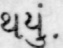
થયું.
